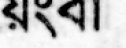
য়েংবা
